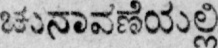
ಚುನಾವಣೆಯಲ್ಲಿ
